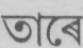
তাৰে
